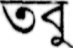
তবু
